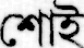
শোই
